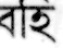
বহি
